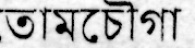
তোমচৌগা
